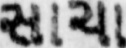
સાચા
